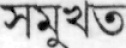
সমুখত
